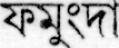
ফমুংদা
